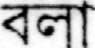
বলা
